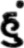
હું
